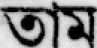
তাম
